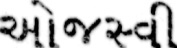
ઓજસ્વી
